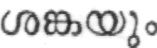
ശങ്കയും
